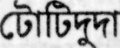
টোটিদুদা
